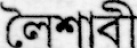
লৈশাবী
